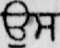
ਉਸ
